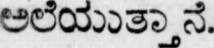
ಅಲೆಯುತ್ತಾನೆ.
